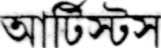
আর্টিস্টস
